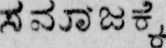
ಸಮಾಜಕ್ಕೆ
